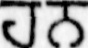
ਹਨ
